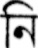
নি
